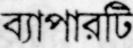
ব্যাপারটি
